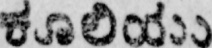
ಕೂಲಿಯು
